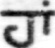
ਹਾਂ
